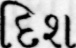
દિશ
